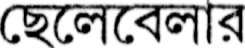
ছেলেবেলার
